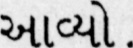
આવ્યો.
